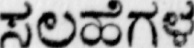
ಸಲಹೆಗಳ
